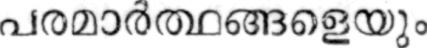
പരമാര്‍ത്ഥങ്ങളെയും
